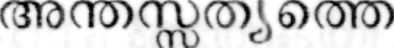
അന്തസ്സത്യത്തെ
